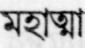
মহাত্মা
